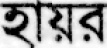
হায়র
